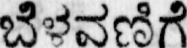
ಬೆಳವಣಿಗೆ
